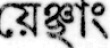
য়েঞ্ছাং
